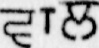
ਵਾਲ
